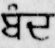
ਬੰਦ
